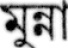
মুন্না
